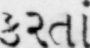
કરતાં
